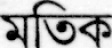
মতিক
